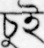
চুই
